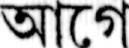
আগে
